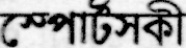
স্পোর্টসকী
